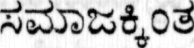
ಸಮಾಜಕ್ಕಿಂತ
